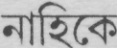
নাহিকে
